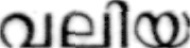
വലിയ
